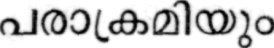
പരാക്രമിയും
